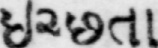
ઇચ્છતા
